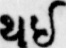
થઈ
